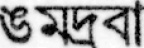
ঙমদ্রবা
